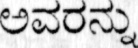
ಅವರನ್ನು
